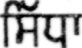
ਸਿੱਧਾ
